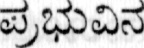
ಪ್ರಭುವಿನ
